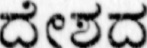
ದೇಶದ
